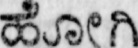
ಹೋಗಿ
